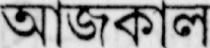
আজকাল
